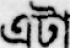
এটা
